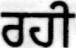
ਰਹੀ
